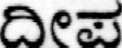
ದೀಪ
